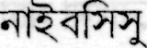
নাইবসিসু
